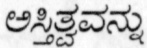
ಅಸ್ತಿತ್ವವನ್ನು
